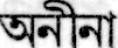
অনীনা
